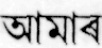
আমাৰ
